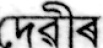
দেৱীৰ
